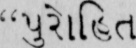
“પુરોહિત
